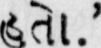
હતો.'
